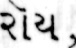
રૉય,
